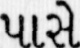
પાસે
